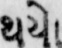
થયો
